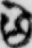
છે
